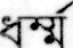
ধর্ম্ম
